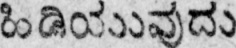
ಹಿಡಿಯುವುದು
